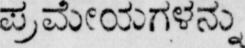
ಪ್ರಮೇಯಗಳನ್ನು
